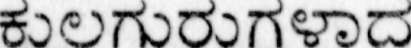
ಕುಲಗುರುಗಳಾದ
